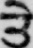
ਤੇ
